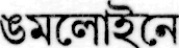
ঙমলোইনে
